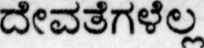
ದೇವತೆಗಳೆಲ್ಲ
